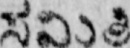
ಸಮಿತಿ
